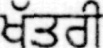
ਖੱਤਰੀ
